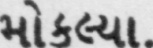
મોકલ્યા.
